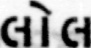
લોલ
